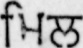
ਮਿਲ
